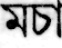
মচা
